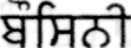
ਬੌਸਿਨੀ
